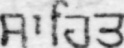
ਸਾਹਿਤ
